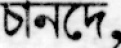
চানদে,
